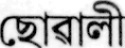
ছোৱালী
